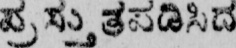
ಪ್ರಸ್ತುತಪಡಿಸಿದ
